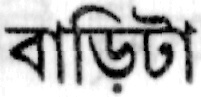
বাড়িটা
